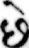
છે
